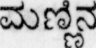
ಮಣ್ಣಿನ
